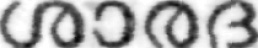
ശാരദ
